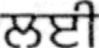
ਲਈ
